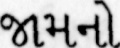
જામનો
